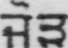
ਜੋੜ
